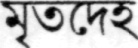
মৃতদেহ
